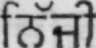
ਨਿੱਜੀ
